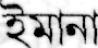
ইমানা
